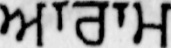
ਆਰਾਮ
